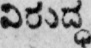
ವಿರುದ್ಧ
